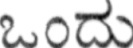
ಒಂದು
